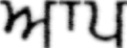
ਆਪ
